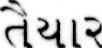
તૈયાર
